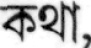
কথা,
